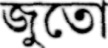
জুতো
